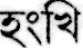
হংখি
